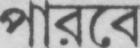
পারবে
